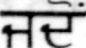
ਜਦੋਂ
